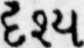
દૃશ્ય
